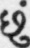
છું
